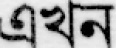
এখন
